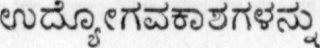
ಉದ್ಯೋಗವಕಾಶಗಳನ್ನು
